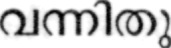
വന്നിതു
